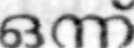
ഒന്ന്
